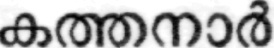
കത്തനാര്‍
